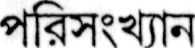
পরিসংখ্যান
